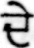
ਦੇ
